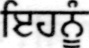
ਇਹਨੂੰ
